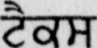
ਟੈਕਸ
